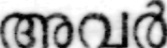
അവര്‍
